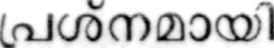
പ്രശ്നമായി
